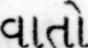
વાતો
